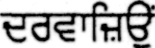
ਦਰਵਾਜ਼ਿਉਂ
